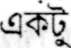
একটু
